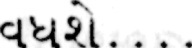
વધશે....
